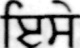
ਇਸੇ
